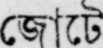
জোটে
